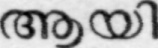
ആയി
